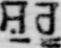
ਸ਼ੁਰੂ
